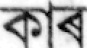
কাৰ
